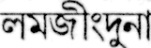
লমজীংদুনা
